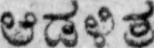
ಆಡಳಿತ
